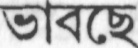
ভাবছে
